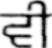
ਵੀ
